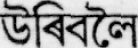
উৰিবলৈ
